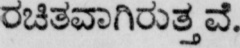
ರಚಿತವಾಗಿರುತ್ತವೆ.
